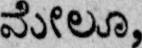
ಮೇಲೂ,
